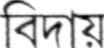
বিদায়
